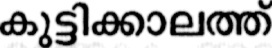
കുട്ടിക്കാലത്ത്
